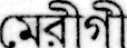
মেরীগী
